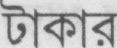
টাকার
